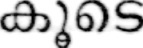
കൂടെ
